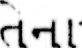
તેના
